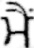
ਮੈਂ
